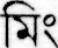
মিং
